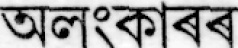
অলংকাৰৰ
